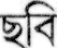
ছবি
